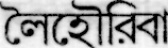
লৈহৌরিবা
